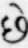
છે
